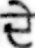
ਦੇ
